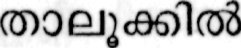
താലൂക്കില്‍
